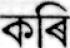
কৰি
